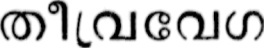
തീവ്രവേഗ
